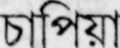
চাপিয়া
